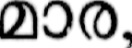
മാര,
